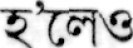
হ'লেও
